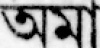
অমা
